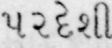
પરદેશી
